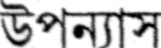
উপন্যাস
